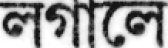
লগালে
